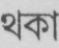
থকা
